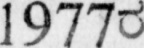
1977ರ
